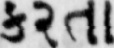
કરતા
